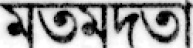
মতমদতা
